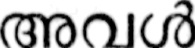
അവള്‍
